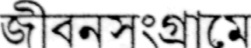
জীবনসংগ্রামে
